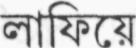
লাফিয়ে
